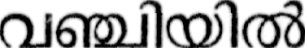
വഞ്ചിയില്‍
